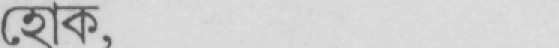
হোক,
